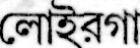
লোইরগা
